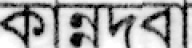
কান্নদবা
